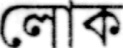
লোক
